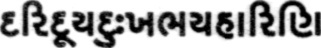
દરિદૂયદુઃખભયહારિણિ
